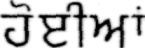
ਹੋਈਆਂ
